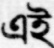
এই
